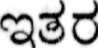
ಇತರ
